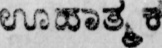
ಊಹಾತ್ಮಕ
